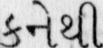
કનેથી
